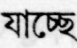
যাচ্ছে
